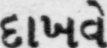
દાખવે
